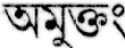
অমুক্তং
